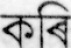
কৰি
